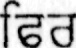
ਫਿਰ
